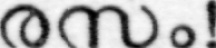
രസം!
